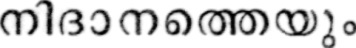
നിദാനത്തെയും
